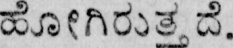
ಹೋಗಿರುತ್ತದೆ.
